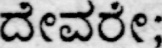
ದೇವರೇ;
